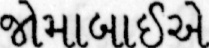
જોમાબાઈએ
